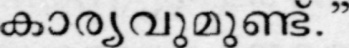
കാര്യവുമുണ്ട്."
